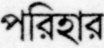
পরিহার
